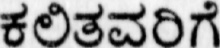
ಕಲಿತವರಿಗೆ
